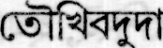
তৌখিবদুদা
